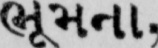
ભૂમના,
